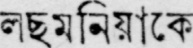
লছমনিয়াকে
